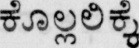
ಕೊಲ್ಲಲಿಕ್ಕೆ
